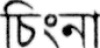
চিংনা
